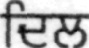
ਦਿਲ
